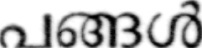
പങ്ങള്‍
